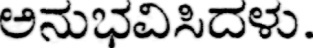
ಅನುಭವಿಸಿದಳು.
